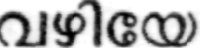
വഴിയേ
